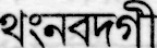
থংনবদগী
